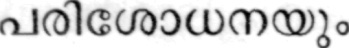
പരിശോധനയും
